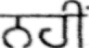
ਨਹੀਂ
